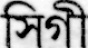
সিগী
